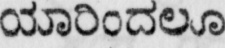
ಯಾರಿಂದಲೂ
